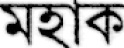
মহাক
